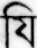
যি
